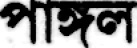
পাঙ্গল
